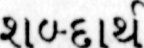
શબ્દાર્થ
